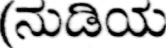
(ನುಡಿಯ
